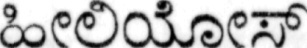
ಹೀಲಿಯೋಸ್
